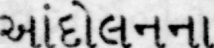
આંદોલનના
